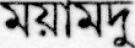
ময়ামদু
